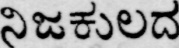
ನಿಜಕುಲದ
